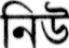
নিউ
